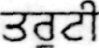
ਤਰੁਟੀ
